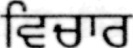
ਵਿਚਾਰ
